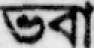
ভবা
